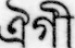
ঐগী
